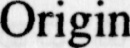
Origin
